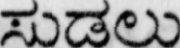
ಸುಡಲು
